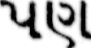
પણ
